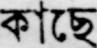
কাছে
